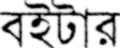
বইটার
